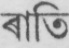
ৰাতি
